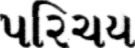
પરિચય
